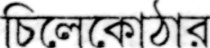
চিলেকোঠার
